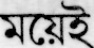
ময়েই
